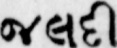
જલદી
